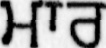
ਮਾਰ
